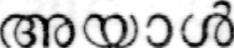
അയാള്‍
